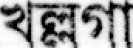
খল্লগা
